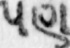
પણ
